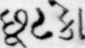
છૂટકો
